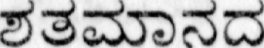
ಶತಮಾನದ
